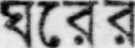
ঘরের
